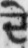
ਦੇ
